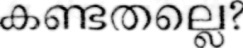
കണ്ടതല്ലെ?
